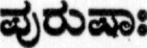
ಪುರುಷಾಃ
